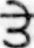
ਤੇ
